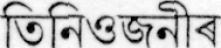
তিনিওজনীৰ
